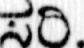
ಸರಿ.
